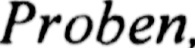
Proben,
